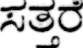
ಸತ್ತರೆ
